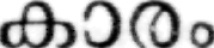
കാരം
